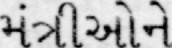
મંત્રીઓને
